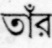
তাঁর
